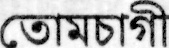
তোমচাগী
